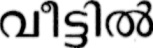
വീട്ടില്‍
